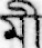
মী
